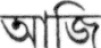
আজি
